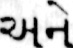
અને
